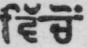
ਵਿੱਚੋਂ
